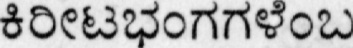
ಕಿರೀಟಭಂಗಗಳೆಂಬ
